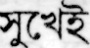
সুখেই
